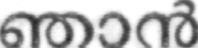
ഞാന്‍
